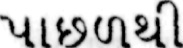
પાછળથી
